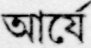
আর্যে
